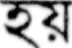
হয়
